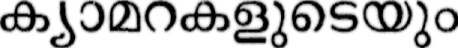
ക്യാമറകളുടെയും
